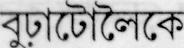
বুঢ়াটোলৈকে
